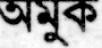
অমুক
